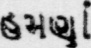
હમણાં
